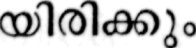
യിരിക്കും
